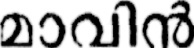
മാവിന്‍
